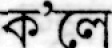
ক'লে
